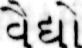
વૈધો
